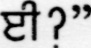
ਈ?''
